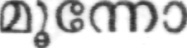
മൂന്നോ
